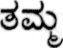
ತಮ್ಮ
